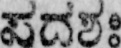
ಪದಶಃ
